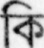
কি
